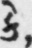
કે,
